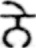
ਨੇ
